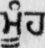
ਮੂੰਹ
